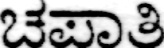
ಚಪಾತಿ
